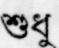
শুধু
